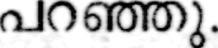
പറഞ്ഞു.
